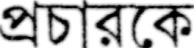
প্রচারকে
